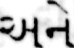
અને
